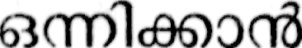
ഒന്നിക്കാന്‍
